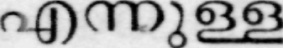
എന്നുള്ള
